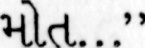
મોત..."
